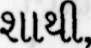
શાથી,
